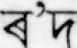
ৰ'দ
